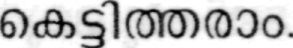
കെട്ടിത്തരാം.
